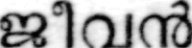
ജീവന്‍
